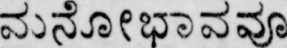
ಮನೋಭಾವವೂ
